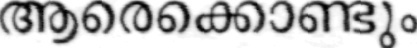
ആരെക്കൊണ്ടും
